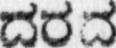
ದರದ
